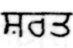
ਸ਼ਰਤ
